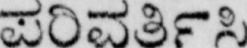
ಪರಿವರ್ತಿಸಿ
